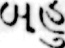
બહુ
